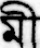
মী
